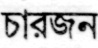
চারজন
